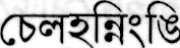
চেলহন্নিংঙি
